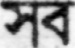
সব
